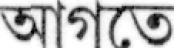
আগতে
